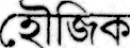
হৌজিক
